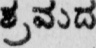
ಶ್ರಮದ
